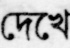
দেখে
